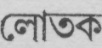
লোতক
